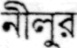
নীলুর
